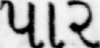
પાર
